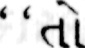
"તો
